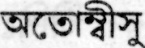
অতোম্বীসু
